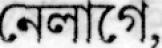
নেলাগে,
